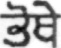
ਭੋਥੇ
